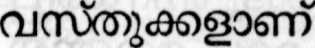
വസ്തുക്കളാണ്
